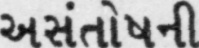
અસંતોષની
